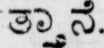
ತ್ತಾನೆ.
